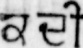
ਕਦੀ
